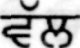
ਵੱਲ
